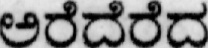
ಅರೆದೆರೆದ
